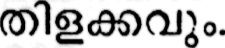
തിളക്കവും.
